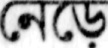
নেড়ে
